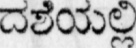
ದಶೆಯಲ್ಲಿ
